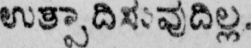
ಉತ್ಪಾದಿಸುವುದಿಲ್ಲ.
